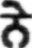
ਨੇ
